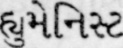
હ્યુમેનિસ્ટ
